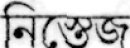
নিস্তেজ
